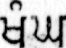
ਖੰਘ
